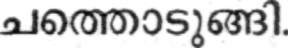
ചത്തൊടുങ്ങി.
